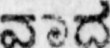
ವಾದ
